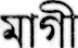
মাগী
